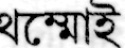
থম্মোই
